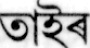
তাইৰ
